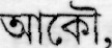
আকৌ,
